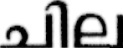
ചില
